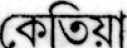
কেতিয়া
